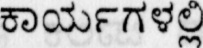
ಕಾರ್ಯಗಳಲ್ಲಿ
